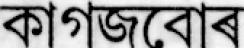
কাগজবোৰ
